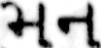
મન
